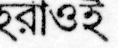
হরাওই
